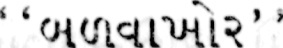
"બળવાખોર"
